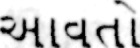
આવતો
